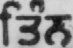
ਤਿੰਨ
